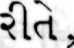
રીતે,
